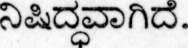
ನಿಷಿದ್ಧವಾಗಿದೆ.
